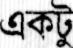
একটু
